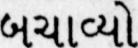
બચાવ્યો
